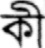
কী
